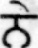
ਨੇ
